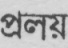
প্ৰলয়
